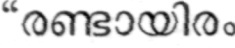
“രണ്ടായിരം
